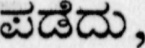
ಪಡೆದು,
